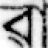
ৱা
